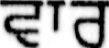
ਵਾਰ
